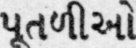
પૂતળીઓ
